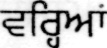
ਵਰ੍ਹਿਆਂ
